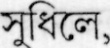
সুধিলে,
